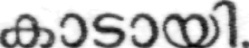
കാടായി.
